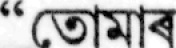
"তোমাৰ
